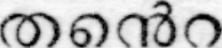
തന്റെ
